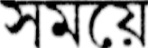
সময়ে
